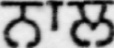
ਨਾਲ
